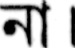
না।
